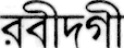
রবীদগী
